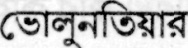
ভোলুনতিয়ার
